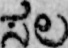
ಸಲ
